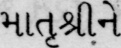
માતૃશ્રીને
